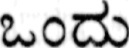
ಒಂದು
